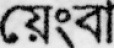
য়েংবা
